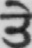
ਤੇ
